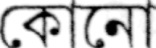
কোনো
